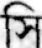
সি
